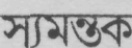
স্যমন্তক
